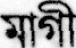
মাগী
